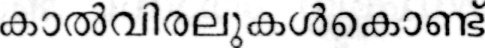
കാല്‍വിരലുകള്‍കൊണ്ട്
